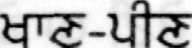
ਖਾਣ-ਪੀਣ
